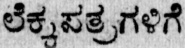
ಲೆಕ್ಕಪತ್ರಗಳಿಗೆ
